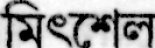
মিৎশেল
